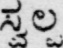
ಸ್ವಲ್ಪ
